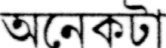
অনেকটা
